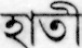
হাতী
